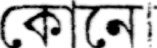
কোনো
